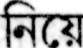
নিয়ে
